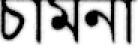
চামনা
